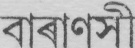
বাৰাণসী
